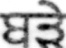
ਬੜੇ
